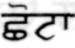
ਛੋਟਾ
